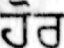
ਹੋਰ
